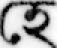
হে
